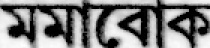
মমাবোক
